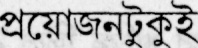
প্রয়োজনটুকুই
